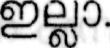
ഇല്ലാ.
